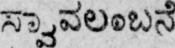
ಸ್ವಾವಲಂಬನೆ
